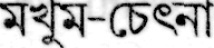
মখুম-চেৎনা
